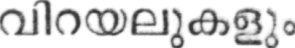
വിറയലുകളും
